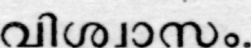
വിശ്വാസം.
